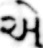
એ
